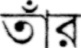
তাঁর
